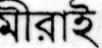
মীরাই
